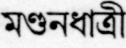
মণ্ডনধাত্রী
